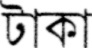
টাকা
